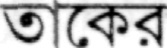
তাকের
